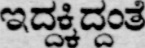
ಇದ್ದಕ್ಕಿದ್ದಂತೆ
